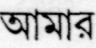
আমার
